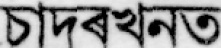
চাদৰখনত
